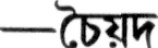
-চৈয়দ
